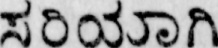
ಸರಿಯಾಗಿ
